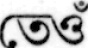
তেওঁ
